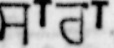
ਸਾਰਾ
